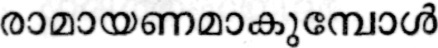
രാമായണമാകുമ്പോള്‍
